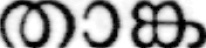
താങ്ക
